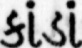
કાંડાં
